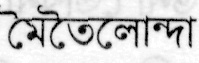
মৈতৈলোন্দা
